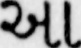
આ
